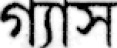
গ্যাস
